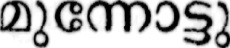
മുന്നോട്ടു
